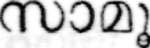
സാമൂ
